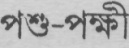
পশু-পক্ষী
